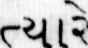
ત્યારે
